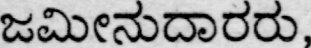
ಜಮೀನುದಾರರು,
